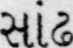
સાંઢ
